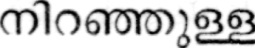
നിറഞ്ഞുള്ള
